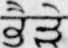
ਭੈੜੇ
